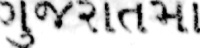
ગુજરાતમાં
